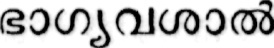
ഭാഗ്യവശാല്‍
